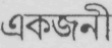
একজনী
